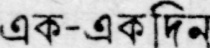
এক-একদিন
